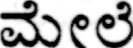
ಮೇಲೆ
